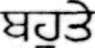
ਬਹੁਤੇ
